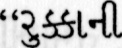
"રુક્કાની
